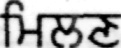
ਮਿਲਣ
